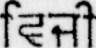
ਵਿਜੀ
